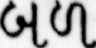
બળ
